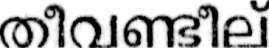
തീവണ്ടീല്
